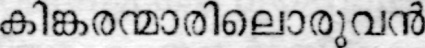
കിങ്കരന്മാരിലൊരുവന്‍
